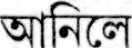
আনিলে
